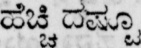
ಹೆಚ್ಚಿದಷ್ಟೂ
